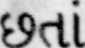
છતાં
